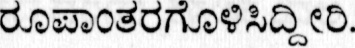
ರೂಪಾಂತರಗೊಳಿಸಿದ್ದೀರಿ.
